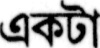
একটা
